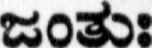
ಜಂತುಃ
